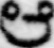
ಆ
